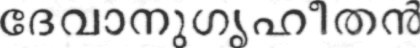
ദേവാനുഗൃഹീതന്‍
